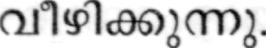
വീഴിക്കുന്നു.
